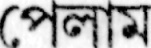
পেলাম
